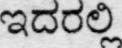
ಇದರಲ್ಲಿ
